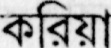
করিয়া
